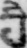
ਹੈ
